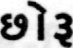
છોરૂ
